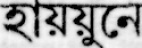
হায়য়ুনে
